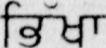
ਭਿੱਖਾ
